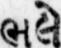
ભલે
